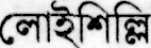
লোইশিল্লি
